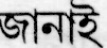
জানাই
